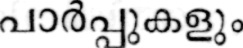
പാര്‍പ്പുകളും
